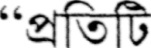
“প্রতিটি
